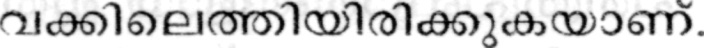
വക്കിലെത്തിയിരിക്കുകയാണ്.
